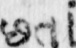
છતાં
